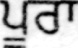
ਪੂਰਾ
